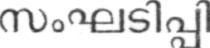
സംഘടിപ്പി
